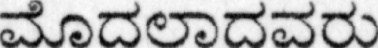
ಮೊದಲಾದವರು
